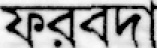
ফরবদা
